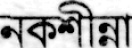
নকশীন্না
